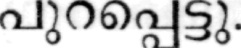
പുറപ്പെട്ടു.
